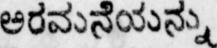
ಅರಮನೆಯನ್ನು
